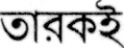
তারকই
